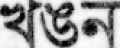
খঙন
